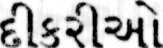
દીકરીઓ
